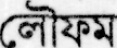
লৌফম
